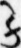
કે
